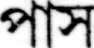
পাস
